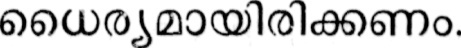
ധൈര്യമായിരിക്കണം.
